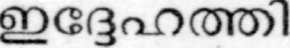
ഇദ്ദേഹത്തി
